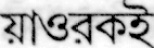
য়াওরকই
